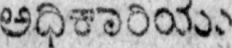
ಅಧಿಕಾರಿಯು
